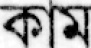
কাম
